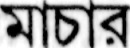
মাচার
